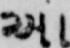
આ
